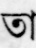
তা
